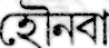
হৌনবা
